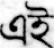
এই
